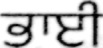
ਭਾਈ
